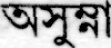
অসুম্না
